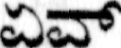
ಏವ್
